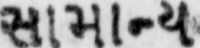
સામાન્ય
